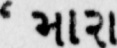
'મારા
